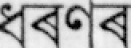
ধৰণৰ
